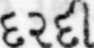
દરદી
